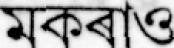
মকৰাও
